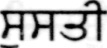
ਸੁਸਤੀ
